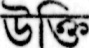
উক্তি
